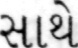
સાથે
